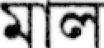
মাল
